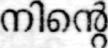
നിന്റെ
